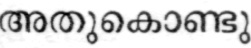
അതുകൊണ്ടു
